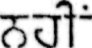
ਨਹੀਂ
